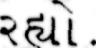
રહ્યો.
